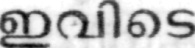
ഇവിടെ
